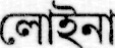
লোইনা
